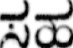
ಸಹ
